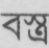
বস্ত্ৰ
